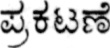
ಪ್ರಕಟಣೆ
